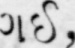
ગઈ,
